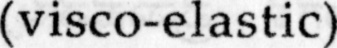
(visco-elastic)
